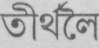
তীৰ্থলৈ
